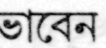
ভাবেন
